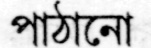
পাঠানো
